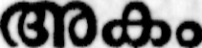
അകം
